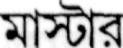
মাস্টার
